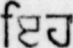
ਇਹ
